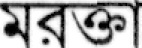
মরক্তা
